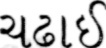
ચઢાઈ
